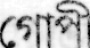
গোপী
